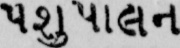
પશુપાલન
